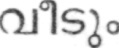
വീടും
